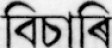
বিচাৰি
